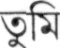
তুমি
